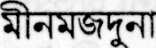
মীনমজদুনা
